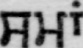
ਸਮਾਂ
